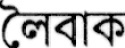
লৈবাক
